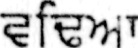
ਵਢਿਆ
